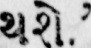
થશે.'
